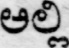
ಅಲ್ಲಿ
